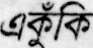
একুঁকি
